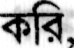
করি,
